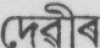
দেৱীৰ
